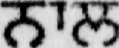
ਨਾਲ
